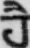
ਹੈ
